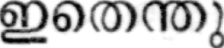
ഇതെന്തു
